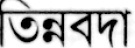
তিন্নবদা
